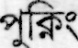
পুক্নিং
